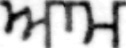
ਆਮ
